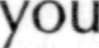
you
